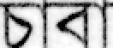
চাবা
